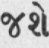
જશે
